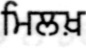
ਮਿਲਖ਼
